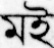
মই
